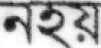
নহয়
